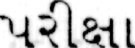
પરીક્ષા
